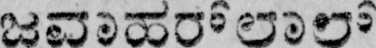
ಜವಾಹರ್ ಲಾಲ್
